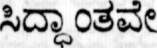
ಸಿದ್ಧಾಂತವೇ
